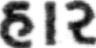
હાર
